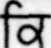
ਕਿ
